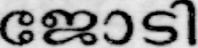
ജോടി
